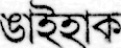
ঙাইহাক
